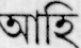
আহি
